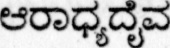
ಆರಾಧ್ಯದೈವ
